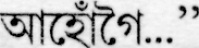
আহোঁগৈ..."
